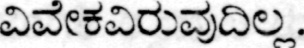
ವಿವೇಕವಿರುವುದಿಲ್ಲ.
